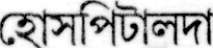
হোসপিটালদা
